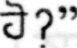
ਹੋ?''
